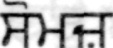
ਸੋਮਜ਼
